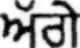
ਅੱਗੇ
